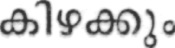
കിഴക്കും
